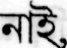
নাই,
